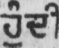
ਹੁੰਦੀ
